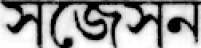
সজেসন
